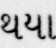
થયા
